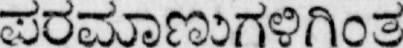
ಪರಮಾಣುಗಳಿಗಿಂತ
